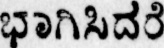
ಭಾಗಿಸಿದರೆ
